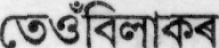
তেওঁবিলাকৰ
